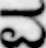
ವ
